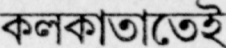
কলকাতাতেই
